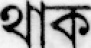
থাক
